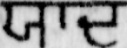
ਯਾਦ
